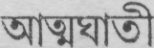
আত্মঘাতী
